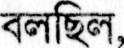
বলছিল,
